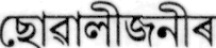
ছোৱালীজনীৰ
